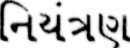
નિયંત્રણ
